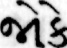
જોકે
